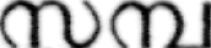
സമ്പ
